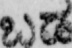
ಬಡ
